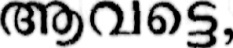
ആവട്ടെ,
